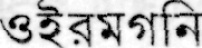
ওইরমগনি
